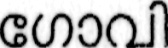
ഗോവി
